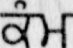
ਕੰਮ
